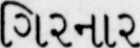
ગિરનાર
